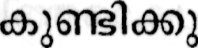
കുണ്ടിക്കു
